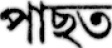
পাছত
